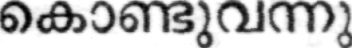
കൊണ്ടുവന്നു
